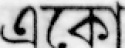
একো
